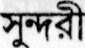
সুন্দরী
